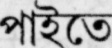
পাইতে
